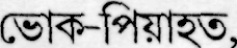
ভোক-পিয়াহত,
